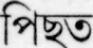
পিছত
